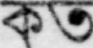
কত
